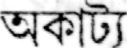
অকাট্য
